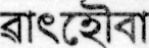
ৱাৎহৌবা
